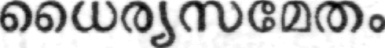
ധൈര്യസമേതം
